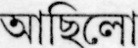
আছিলো
